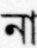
না
